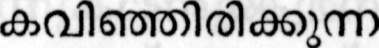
കവിഞ്ഞിരിക്കുന്ന
